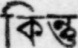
কিন্তু
